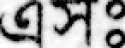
এসঃ
